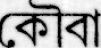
কৌবা
